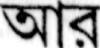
আর
